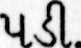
પડી.
